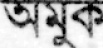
অমুক
